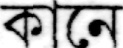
কানে
